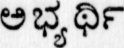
ಅಭ್ಯರ್ಥಿ
